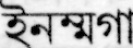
ইনম্মগা
